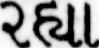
રહ્યા
